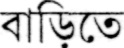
বাড়িতে
